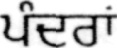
ਪੰਦਰਾਂ
